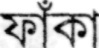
ফাঁকা
